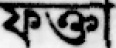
ফক্তা
